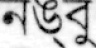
নঙবু
